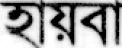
হায়বা
